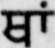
ਥਾਂ
